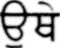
ਉਥੇ
